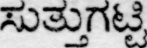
ಸುತ್ತುಗಟ್ಟಿ
